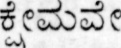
ಕ್ಷೇಮವೇ
